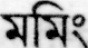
মমিং
